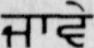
ਜਾਵੇ
